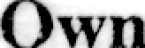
Own
